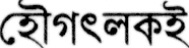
হৌগৎলকই
